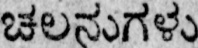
ಚಲನುಗಳು
